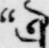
‘‘ঐ
